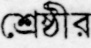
শ্রেষ্ঠীর
